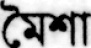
মৈশা
